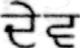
ਦੇਵ
